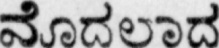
ಮೊದಲಾದ
